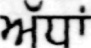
ਅੱਧਾਂ
